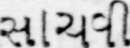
સાચવી
